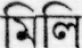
মিলি
